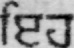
ਇਹ
